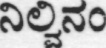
ನಿಲ್ವಿನಂ
